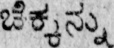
ಚೆಕ್ಕನ್ನು
